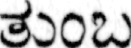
ತುಂಬ
